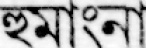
হুমাংনা
